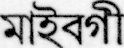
মাইবগী
